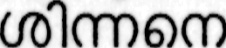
ശിന്നനെ
